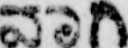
ವಾಗಿ
